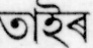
তাইৰ
